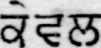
ਕੇਵਲ
